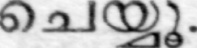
ചെയ്യൂ.
